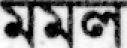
মমল
